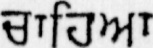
ਚਾਹਿਆ
